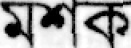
মশক
